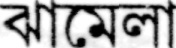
ঝামেলা
